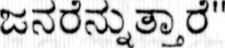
ಜನರೆನ್ನುತ್ತಾರೆ”
